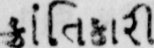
ક્રાંતિકારી
